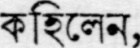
কহিলেন,
